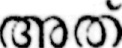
അത്
